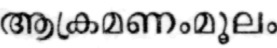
ആക്രമണംമൂലം
